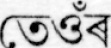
তেওঁৰ
